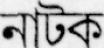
নাটক
